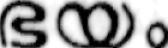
ഭയം
